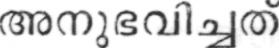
അനുഭവിച്ചത്
